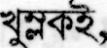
খুম্লকই,
